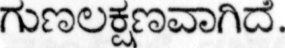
ಗುಣಲಕ್ಷಣವಾಗಿದೆ.
